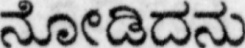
ನೋಡಿದನು
